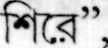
শিরে”,
